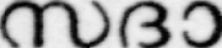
സദാ
